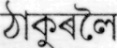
ঠাকুৰলৈ
